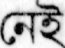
নেই
